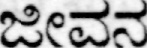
ಜೀವನ
